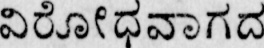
ವಿರೋಧವಾಗದ
